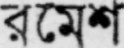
রমেশ
